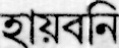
হায়বনি
